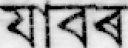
যাবৰ
